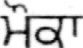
ਮੌਕਾ
